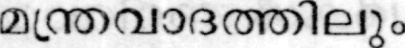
മന്ത്രവാദത്തിലും
